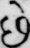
છે
